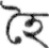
হৈ
